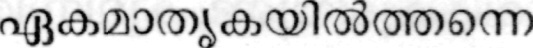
ഏകമാതൃകയില്‍ത്തന്നെ
